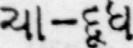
ચા-દૂધ
